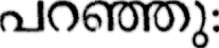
പറഞ്ഞു:
